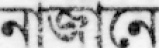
নাজানে
